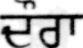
ਦੌਰਾ
